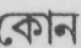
কোন
